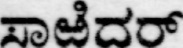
ಸಾಱೆದರ್
